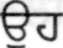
ਉਹ
